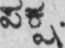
ಪಕ್ಷ.
